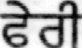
ਫੇਰੀ
